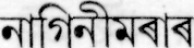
নাগিনীমৰাৰ
